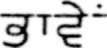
ਭਾਵੇਂ
